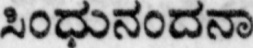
ಸಿಂಧುನಂದನಾ
